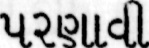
પરણાવી
